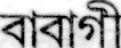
বাবাগী
